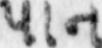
પાન
